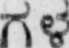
ಗಳ
